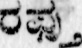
ರಫ್ತು
